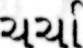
ચર્ચા
